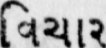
વિચાર
